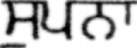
ਸੁਪਨਾ
